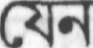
যেন
